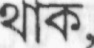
থাক,
